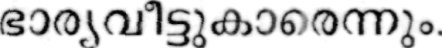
ഭാര്യവീട്ടുകാരെന്നും.
